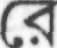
রে
